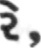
રે,
